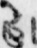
હો
